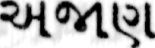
અજાણ
